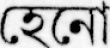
হেনো
